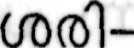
ശരി-
